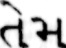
તેમ
